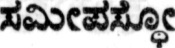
ಸಮೀಪಸ್ಥೋ
